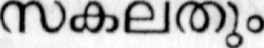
സകലതും
